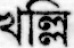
খল্লি
